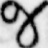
જ
